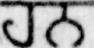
ਹਨ
